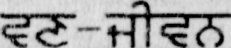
ਵਣ-ਜੀਵਨ
